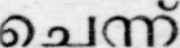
ചെന്ന്
